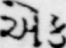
એક
